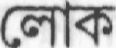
লোক
